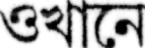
ওখানে
